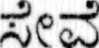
ಸೇವೆ
